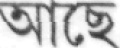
আছে
